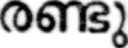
രണ്ടു
